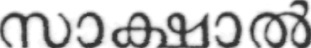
സാക്ഷാല്‍
